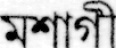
মশাগী
